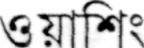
ওয়াশিং
